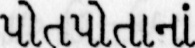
પોતપોતાનાં
